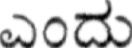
ಎಂದು
